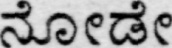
ನೋಡೇ
